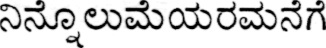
ನಿನ್ನೊಲುಮೆಯರಮನೆಗೆ
